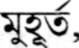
মুহূর্ত,
